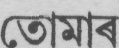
তোমাৰ
